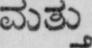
ಮತ್ತು
